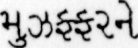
મુઝફ્ફરને
